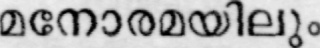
മനോരമയിലും
